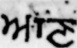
ਆਣ
